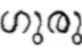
ഗുരു
